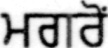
ਮਗਰੋਂ
